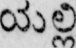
ಯಲ್ಲಿ
